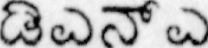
ಡಿಎನ್ಎ
